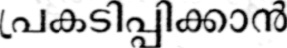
പ്രകടിപ്പിക്കാന്‍
